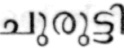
ചുരുട്ടി
